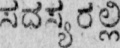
ಸದಸ್ಯರಲ್ಲಿ
